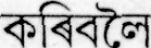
কৰিবলৈ
